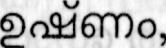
ഉഷ്ണം,
